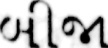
બીજા
